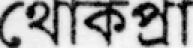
থোকপ্রা
